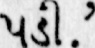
પડી.'
